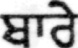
ਬਾਰੇ
